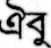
ঐবু
